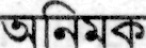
অনিমক
